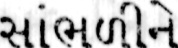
સાંભળીને
